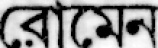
রোমেন
